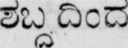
ಶಬ್ದದಿಂದ
